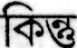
কিন্তু
